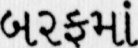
બરફમાં
